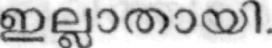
ഇല്ലാതായി.
